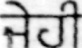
ਜੇਹੀ
